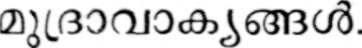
മുദ്രാവാക്യങ്ങള്‍.
